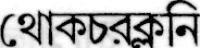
থোকচরক্লনি
